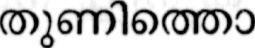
തുണിത്തൊ
